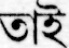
তাই
